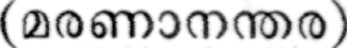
(മരണാനന്തര)
